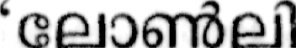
‘ലോണ്‍ലി
